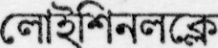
লোইশিনলক্লে
